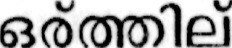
ഒര്ത്തില്
